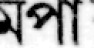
মপা
